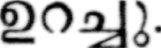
ഉറച്ചു.
